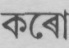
কৰো
